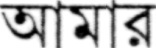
আমার
